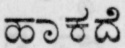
ಹಾಕದೆ
